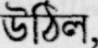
উঠিল,
